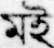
মই
